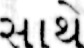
સાથે
